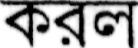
করল
